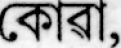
কোৱা,
